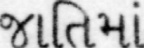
જાતિમાં
